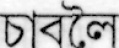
চাবলৈ
